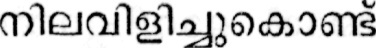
നിലവിളിച്ചുകൊണ്ട്
